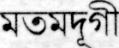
মতমদূগী
